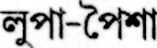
লুপা-পৈশা
